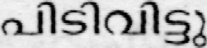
പിടിവിട്ടു
